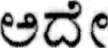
ಅದೇ
